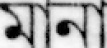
মানা
